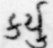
કર્યુ
